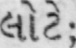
લોટે;
